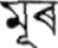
মূৰ
